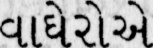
વાઘેરોએ
